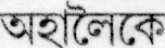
অহালৈকে
